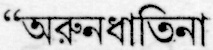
“অরুনধাতিনা
